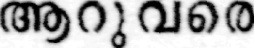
ആറുവരെ
